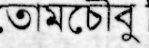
তোমচৌবু
